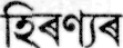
হিৰণ্যৰ
